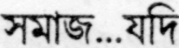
সমাজ...যদি
